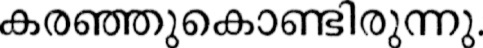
കരഞ്ഞുകൊണ്ടിരുന്നു.
